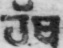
ਹੱਥ
